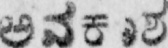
ಅವಕಾಶ
